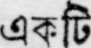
একটি
